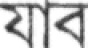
যাব
